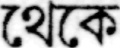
থেকে
